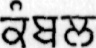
ਕੰਬਲ
